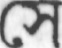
সে
